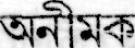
অনীমক
